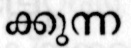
ക്കുന്ന
